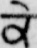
ਕੇ
